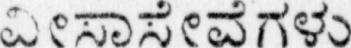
ವೀಸಾಸೇವೆಗಳು
